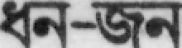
ধন-জন
